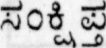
ಸಂಕ್ಷಿಪ್ತ
